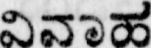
ವಿವಾಹ
